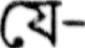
যে-
